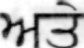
ਅਤੇ
